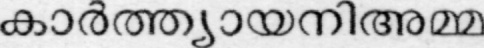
കാര്‍ത്ത്യായനിഅമ്മ
